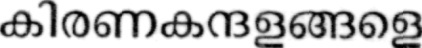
കിരണകന്ദളങ്ങളെ
